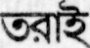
তরাই
